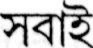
সবাই
